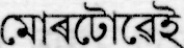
মোৰটোৱেই
